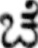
ಚೆ
